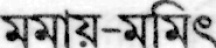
মমায়-মমিৎ
